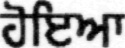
ਹੋਇਆ
